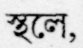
স্থলে,
